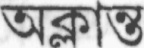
অক্লান্ত
